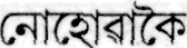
নোহোৱাকৈ
